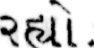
રહ્યો.
